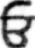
ਓ
